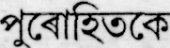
পুৰোহিতকে
